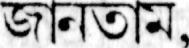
জানতাম,
